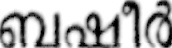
ബഷീര്‍
